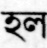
হল
